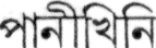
পানীখিনি
